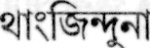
থাংজিন্দুনা
